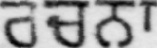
ਰਚਨਾ
